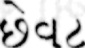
છેવટ
